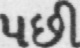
પછી
